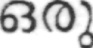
ഒരു
